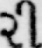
રી
